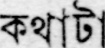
কথাটা
